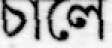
চালে
